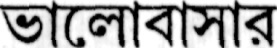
ভালোবাসার
